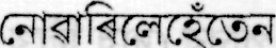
নোৱাৰিলেহেঁতেন
